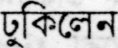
ঢুকিলেন
